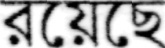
রয়েছে
